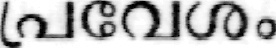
പ്രവേശം
